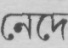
নেদে
